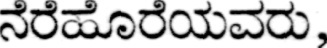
ನೆರೆಹೊರೆಯವರು,
